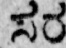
ಸರ
